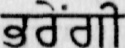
ਭਰੇਂਗੀ
